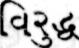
વિરુદ્ધ
